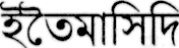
ইতৈমাসিদি
